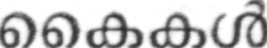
കൈകള്‍
